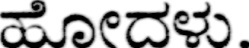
ಹೋದಳು.
